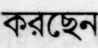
করছেন
